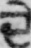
ਦੇ
